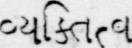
વ્યક્તિત્વ
